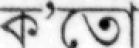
ক'তো
